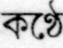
কণ্ঠে
